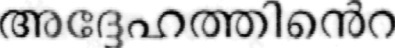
അദ്ദേഹത്തിന്റെ
